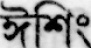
ঈশিং
